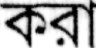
করা
